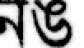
নঙ
